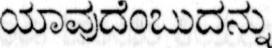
ಯಾವುದೆಂಬುದನ್ನು
